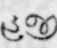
હજી
